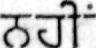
ਨਹੀਂ
